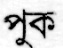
পুক
